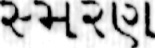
સ્મરણ
